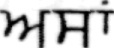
ਅਸਾਂ
